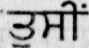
ਤੁਸੀਂ
